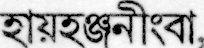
হায়হঞ্জনীংবা
